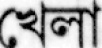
খেলা
